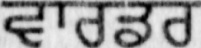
ਵਾਰਡਰ
